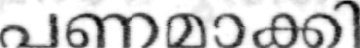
പണമാക്കി
